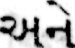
અને
